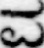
ವ
